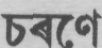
চৰণে
